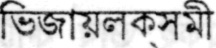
ভিজায়লক্‌সমী
